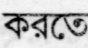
করতে
